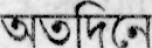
অতদিনে
